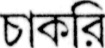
চাকরি
